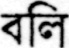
বলি
